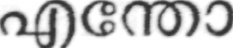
എന്തോ
